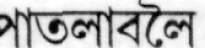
পাতলাবলৈ
